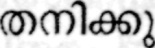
തനിക്കു
